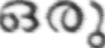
ഒരു
